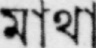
মাথা
